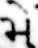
મેં
